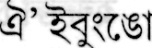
ঐ’ইবুংঙো
